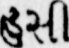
હસી
